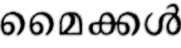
മൈക്കള്‍
